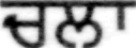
ਚਲਾ
